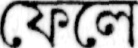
ফেলে
